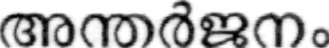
അന്തര്‍ജനം
